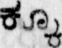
ಕ್ಕೂ
